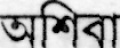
অশিবা
